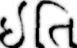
ઇતિ
